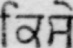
ਕਿਸੇ
